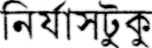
নির্যাসটুকু
